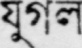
যুগল
